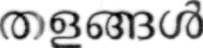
തളങ്ങള്‍
